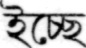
ইচ্ছে
